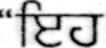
''ਇਹ
